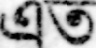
এত
